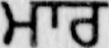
ਮਾਰ
